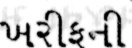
ખરીફની
